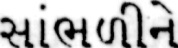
સાંભળીને
